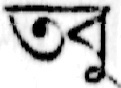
তবু
